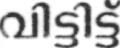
വിട്ടിട്ട്
